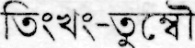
তিংখং-তুম্বৌ
